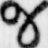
જ
